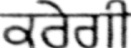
ਕਰੇਗੀ
